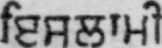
ਇਸਲਾਮੀ
